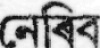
নেৰিব
